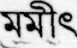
মমীৎ
